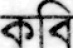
কবি
